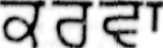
ਕਰਵਾ
